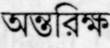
অন্তরিক্ষ
